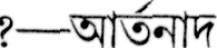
?-আর্তনাদ
